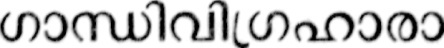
ഗാന്ധിവിഗ്രഹാരാ
